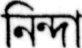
নিন্দা
